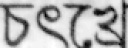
চৎখ্রে
